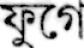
ফুগে
